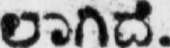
ಲಾಗಿದೆ.
